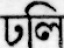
ঢলি
